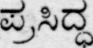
ಪ್ರಸಿದ್ಧ
